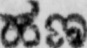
ಹಣ
